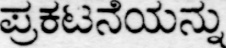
ಪ್ರಕಟನೆಯನ್ನು
